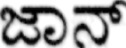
ಜಾನ್
